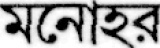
মনোহর
